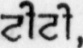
ਟੀਟੀ,
